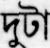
দুটা
